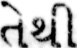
તેથી
